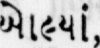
બોલ્યાં,
